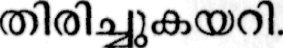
തിരിച്ചുകയറി.
